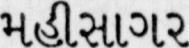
મહીસાગર
